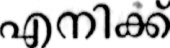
എനിക്ക്
